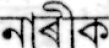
নাৰীক
